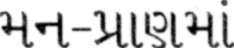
મન-પ્રાણમાં
